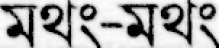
মথং-মথং
